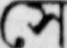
সে
